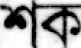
শক
